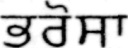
ਭਰੋਸਾ
